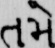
તમે
